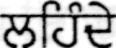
ਲਹਿੰਦੇ
